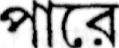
পারে
